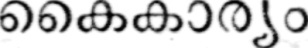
കൈകാര്യം
